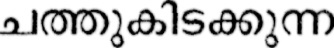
ചത്തുകിടക്കുന്ന
